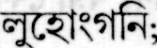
লুহোংগনি;
